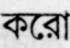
করো
